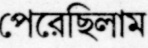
পেরেছিলাম
